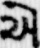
એ
